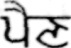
ਪੈਣ
